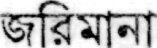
জরিমানা
